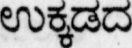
ಉಕ್ಕಡದ
